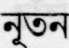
নূতন
